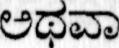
ಅಥವಾ
